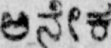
ಅನೇಕ
